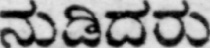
ನುಡಿದರು
